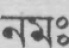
নমঃ
